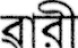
ৱারী
